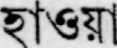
হাওয়া
